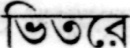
ভিতরে
